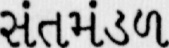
સંતનંડળ
